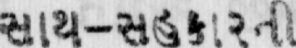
સાથ-સહકારની
